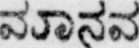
ಮಾನವ
